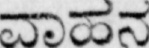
ವಾಹನ
